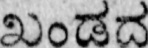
ಖಂಡದ
